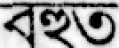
বহুত
